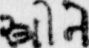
સ્ત્રીને
